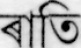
ৰাতি
